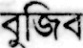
বুজিব
